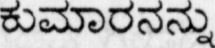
ಕುಮಾರನನ್ನು
